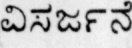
ವಿಸರ್ಜನೆ
